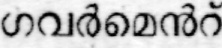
ഗവര്‍മെന്റ്
